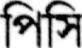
পিসি
